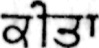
ਕੀਤਾ
